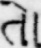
તો
